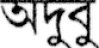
অদুবু
